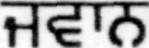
ਜਵਾਨ
